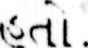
હતો.
